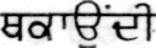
ਥਕਾਉਂਦੀ
